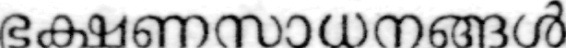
ഭക്ഷണസാധനങ്ങള്‍
